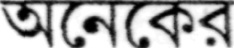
অনেকের
